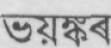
ভয়ঙ্কৰ
